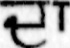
ਦਾ
